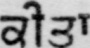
ਕੀਤਾ
